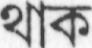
থাক
